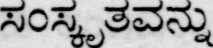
ಸಂಸ್ಕೃತವನ್ನು
